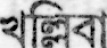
খল্লিবা
